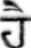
ਹੈ
